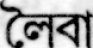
লৈবা
